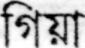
গিয়া
